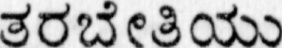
ತರಬೇತಿಯು
